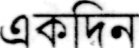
একদিন
